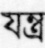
যন্ত্র
